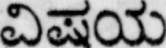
ವಿಷಯ
